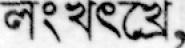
লংখৎখ্রে,
